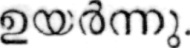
ഉയര്‍ന്നു.
